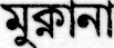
মুক্নানা
